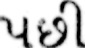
પછી
